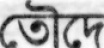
তৌদে
